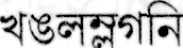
খঙলম্লগনি
